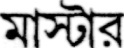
মাস্টার
